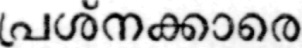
പ്രശ്നക്കാരെ
